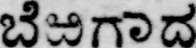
ಬೆಱಗಾದ
